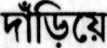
দাঁড়িয়ে
